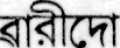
ৱারীদো
